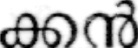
ക്കന്‍
